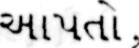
આપતો,
